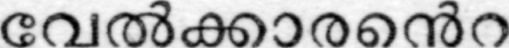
വേല്‍ക്കാരന്റെ
